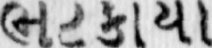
ભટકાયા
